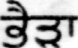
ਭੈੜਾ
